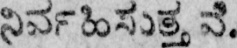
ನಿರ್ವಹಿಸುತ್ತವೆ.
